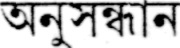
অনুসন্ধান
